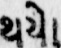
થયો
